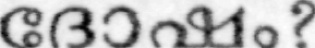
ദോഷം?
